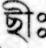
ছীঃ
